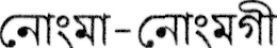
নোংমা-নোংমগী
